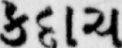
કદાચ
